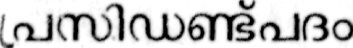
പ്രസിഡണ്ട്പദം
